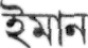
ইমান
